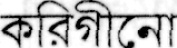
করিগীনো
